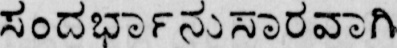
ಸಂದರ್ಭಾನುಸಾರವಾಗಿ
